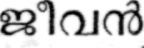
ജീവന്‍
